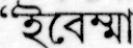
“ইবেম্মা
